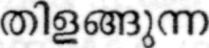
തിളങ്ങുന്ന
